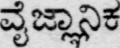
ವೈಜ್ಞಾನಿಕ
